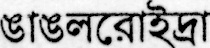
ঙাঙলরোইদ্রা
